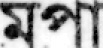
মপা
